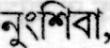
নুংশিবা,
